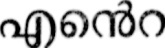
എന്റെ
